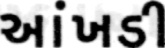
આંખડી
